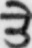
ਤੇ
